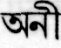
অনী
